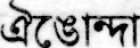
ঐঙোন্দা
